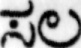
ಸಲ
